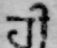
ਹੀ
